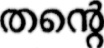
തന്റെ
